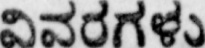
ವಿವರಗಳು
